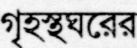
গৃহস্থঘরের
